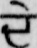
ਦੇ
